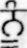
ਨੂੰ
